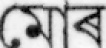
মোৰ
